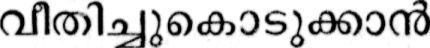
വീതിച്ചുകൊടുക്കാന്‍
